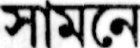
সামনে
